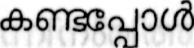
കണ്ടപ്പോള്‍
